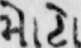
મોટો
